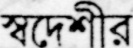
স্বদেশীর
